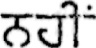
ਨਹੀਂ
